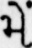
મેં
